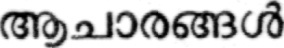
ആചാരങ്ങള്‍
